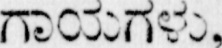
ಗಾಯಗಳು,
